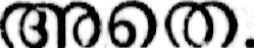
അതെ.
